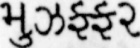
મુઝફ્ફર
